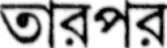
তারপর
